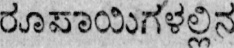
ರೂಪಾಯಿಗಳಲ್ಲಿನ
